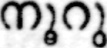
നൂറു
